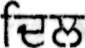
ਦਿਲ
